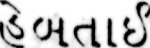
હેબતાઈ
